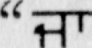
''ਜਾ
